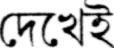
দেখেই
